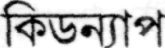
কিডন্যাপ
